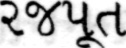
રજપૂત
